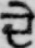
ਦੇ
